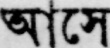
আসে
